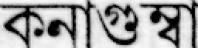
কনাগুম্বা
